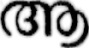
ആ
